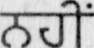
ਨਹੀਂ
